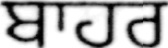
ਬਾਹਰ
